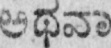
ಅಥವಾ
